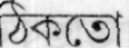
ঠিকতা
